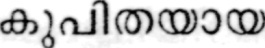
കുപിതയായ
